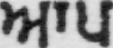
ਆਪ
